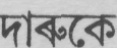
দাৰুকে
